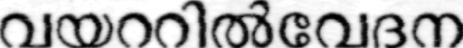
വയററില്‍വേദന
